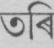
তৰি
